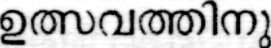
ഉത്സവത്തിനു
